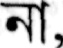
না,
